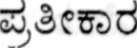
ಪ್ರತೀಕಾರ
